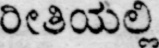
ರೀತಿಯಲ್ಲಿ
